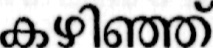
കഴിഞ്ഞ്
